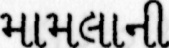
મામલાની
